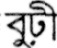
বুঢ়ী
